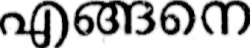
എങ്ങനെ
